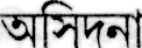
অসিদনা
